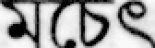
মচেৎ
